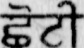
ਛੋਟੀ
